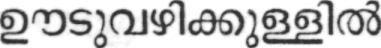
ഊടുവഴിക്കുള്ളില്‍
